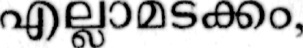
എല്ലാമടക്കം,
